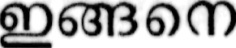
ഇങ്ങനെ
